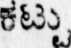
ಕಟ್ಟು
